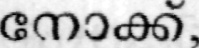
നോക്ക്,
